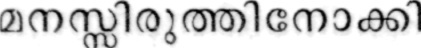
മനസ്സിരുത്തിനോക്കി
